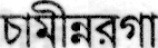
চামীন্নরগা
